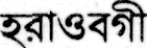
হরাওবগী
